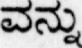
ವನ್ನು
